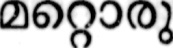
മറ്റൊരു
